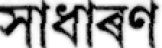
সাধাৰণ
